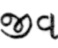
જીવ
